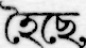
হৈছে,
